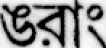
ঙরাং
